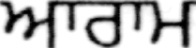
ਆਰਾਮ
